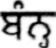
ਬੰਨ੍ਹ
